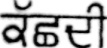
ਕੱਛਦੀ
